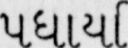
પધાર્યા
